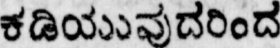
ಕಡಿಯುವುದರಿಂದ
